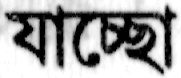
যাচ্ছো
